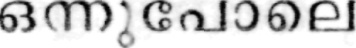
ഒന്നുപോലെ
